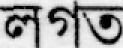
লগত
